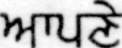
ਆਪਣੇ
